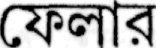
ফেলার
